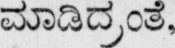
ಮಾಡಿದ್ರಂತೆ,
